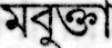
মবুক্তা
